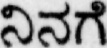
ನಿನಗೆ
